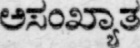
ಅಸಂಖ್ಯಾತ
